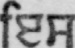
ਇਸ
